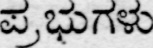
ಪ್ರಭುಗಳು
